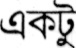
একটু
